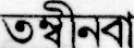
তম্বীনবা
